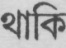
থাকি
